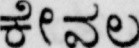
ಕೇವಲ
